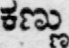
ಕಣ್ಣು
